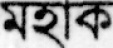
মহাক
